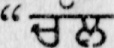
''ਚੱਲ
